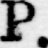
P
